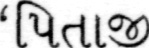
'પિતાજી
